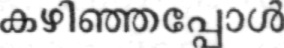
കഴിഞ്ഞപ്പോള്‍
